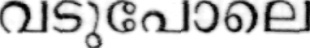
വടുപോലെ
